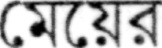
মেয়ের
